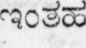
ಇಂತಹ
